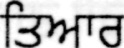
ਤਿਆਰ
